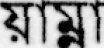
য়াম্না
